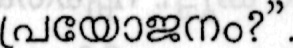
പ്രയോജനം?".
